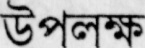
উপলক্ষ
